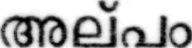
അല്പം
